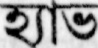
হ্যাভ
